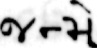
જન્મે
